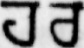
ਹਰ
